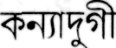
কন্যাদুগী
